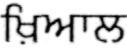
ਖ਼ਿਆਲ
